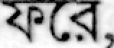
ফরে,
